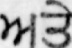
ਅਤੇ
